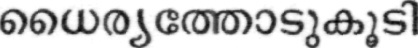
ധൈര്യത്തോടുകൂടി
